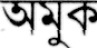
অমুক
